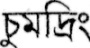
চুমদ্রিং
